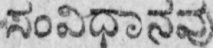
ಸಂವಿಧಾನವು
